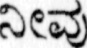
ನೀವು
